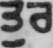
ਤੁਰ
